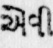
એવી
